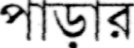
পাড়ার
